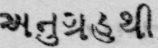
અનુગ્રહથી
